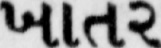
ખાતર
